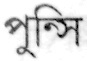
পুন্সি
